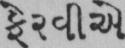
ફેરવીએ
